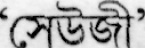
'সেউজী'
